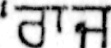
'ਰਾਜ
